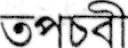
তপচবী
